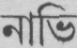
নাভি
